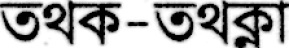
তথক-তথক্না
